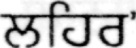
ਲਹਿਰ'
